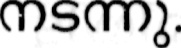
നടന്നു.
